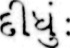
દીધુંઃ
